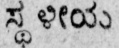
ಸ್ಥಳೀಯ
